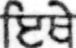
ਇਥੇ
